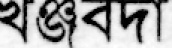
খঞ্জবদা
